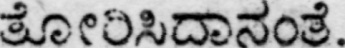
ತೋರಿಸಿದಾನಂತೆ.
